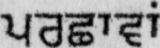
ਪਰਛਾਵਾਂ
